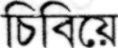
চিবিয়ে
